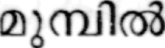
മുമ്പില്‍
